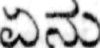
ಏನು
